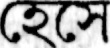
হেসে
